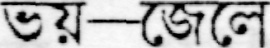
ভয়—জেলে
